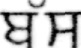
ਬੱਸ
